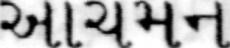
આચમન
